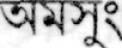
অমসুং
